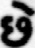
છે
